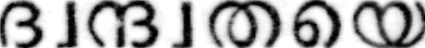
ദ്വന്ദ്വതയെ
